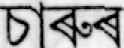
চাৰুৰ
